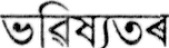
ভৱিষ্যতৰ
